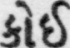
કોઈ
